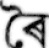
ৰৈ
